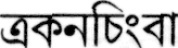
ত্রকনচিংবা
